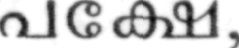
പക്ഷേ,
